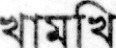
খামখি
